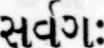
સર્વગઃ
